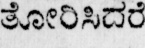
ತೋರಿಸಿದರೆ
